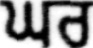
ਘਰ
